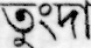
তুংদা
